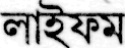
লাইফম
